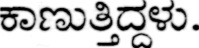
ಕಾಣುತ್ತಿದ್ದಳು.
